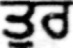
ਤੁਰ
